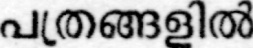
പത്രങ്ങളില്‍
